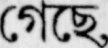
গেছে,
